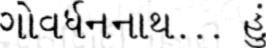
ગોવર્ધનનાથ....હું
